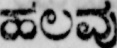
ಹಲವು
